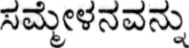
ಸಮ್ಮೇಳನವನ್ನು
